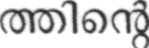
ത്തിന്റെ
